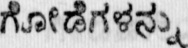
ಗೋಡೆಗಳನ್ನು
